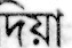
দিয়া
